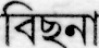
বিছনা
